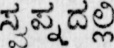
ಸ್ವಪ್ನದಲ್ಲಿ
